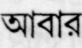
আবার
